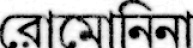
রোমোনিনা
